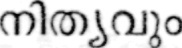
നിത്യവും
